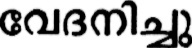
വേദനിച്ചു
